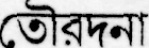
তৌরদনা
